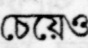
চেয়েও
